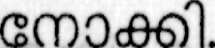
നോക്കി.
